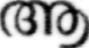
ആ
